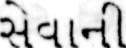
સેવાની
